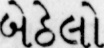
બેઠેલો
